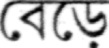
বেড়ে
